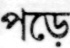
পড়ে
